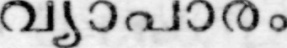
വ്യാപാരം
